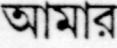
আমার
